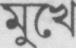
মুখে
